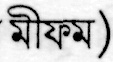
মীফম)
